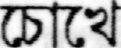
চোখে
